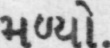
મળ્યો.
